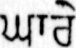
ਘਾਰੇ
